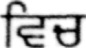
ਵਿਚ
